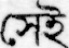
সেই
